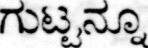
ಗುಟ್ಟನ್ನೂ
